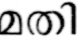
മതി
